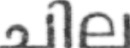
ചില
